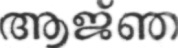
ആജ്ഞ
